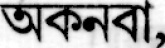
অকনবা,
